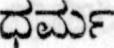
ಧರ್ಮ
